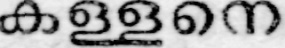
കള്ളനെ
